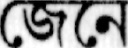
জেনে
